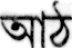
আঠ
